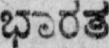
ಭಾರತ
